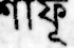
শাফূ
